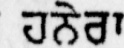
ਹਨੇਰਾ
